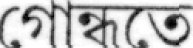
গোন্ধতে
